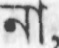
না,
